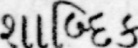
શાબ્દિક
